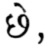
છે,
